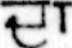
ਦਾ
